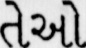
તેઓ
